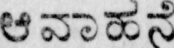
ಆವಾಹನೆ
